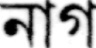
নাগ
